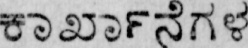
ಕಾರ್ಖಾನೆಗಳ
